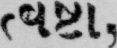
ત્વષ્ટા,
